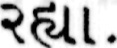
રહ્યા.
